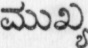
ಮುಖ್ಯ
